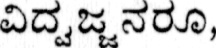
ವಿದ್ವಜ್ಜನರೂ,
